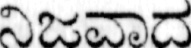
ನಿಜವಾದ
